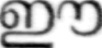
ഈ
